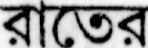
রাতের
